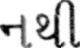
નથી
